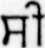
ਸੀ
